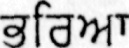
ਭਰਿਆ
